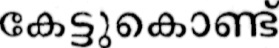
കേട്ടുകൊണ്ട്
